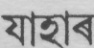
যাহাৰ
